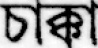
চাক্কা
